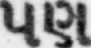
પણ
